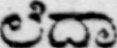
ಲೆದಾ
